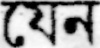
যেন
